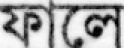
ফালে
